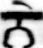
ਨੇ
